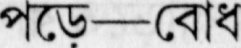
পড়ে-বোধ
